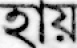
হায়
